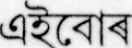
এইবোৰ
